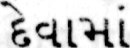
દેવામાં
